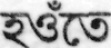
হওঁতে
